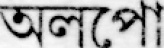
অলপো
